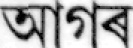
আগৰ
